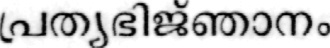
പ്രത്യഭിജ്ഞാനം
